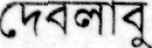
দেবলাবু
